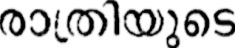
രാത്രിയുടെ
